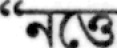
“নত্তে
